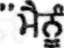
''ਮੈਨੂੰ
